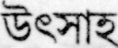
উত্সাহ
